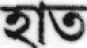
হাত
